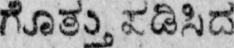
ಗೊತ್ತುಪಡಿಸಿದ
